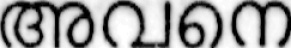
അവനെ
